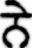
ਨੇ
